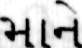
માને
